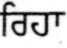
ਰਿਹਾ
